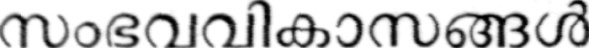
സംഭവവികാസങ്ങള്‍
